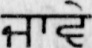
ਜਾਵੇ
